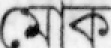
মোক
